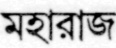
মহারাজ
